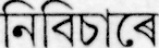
নিবিচাৰে
